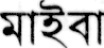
মাইবা
